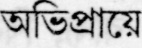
অভিপ্রায়ে
